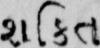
શક્તિ
